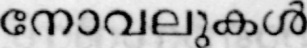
നോവലുകള്‍
